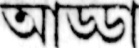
আড্ডা
